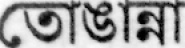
তোঙান্না
